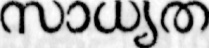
സാധ്യത
